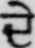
ਦੇ
